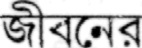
জীবনের
